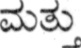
ಮತ್ತು
